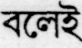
বলেই
